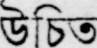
উচিত
